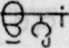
ਉਨ੍ਹਾਂ
